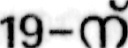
19-ന്
